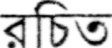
রচিত
